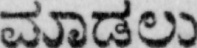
ಮಾಡಲು
